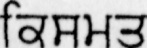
ਕਿਸਮਤ
